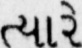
ત્યારે
